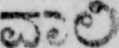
ವಾಲಿ
